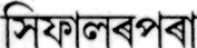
সিফালৰপৰা
